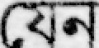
যেন
